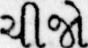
ચીજો
